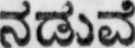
ನಡುವೆ
